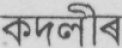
কদলীৰ
